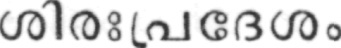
ശിരഃപ്രദേശം
